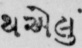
થએલું
